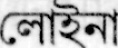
লোইনা
